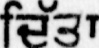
ਦਿੱਤਾ
